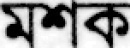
মশক
